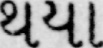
થયા
